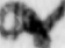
જ
